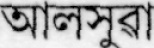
আলসুৱা
